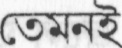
তেমনই
